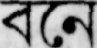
বনে
